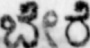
ಬೇರೆ
